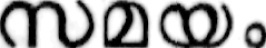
സമയം
